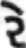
રે
